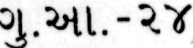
ગુ.આ.-૨૪/
